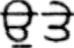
ਉਤੇ
